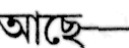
আছে-
